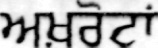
ਅਖ਼ਰੋਟਾਂ
